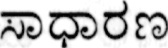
ಸಾಧಾರಣ
